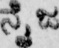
ನೈಜ
